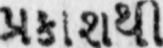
પ્રકાશથી
